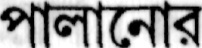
পালানোর
